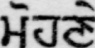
ਮੋਹਣੇ
